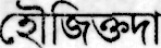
হৌজিক্তদা
